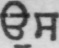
ਉਸ
